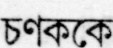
চণককে
